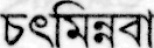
চৎমিন্নবা
